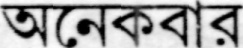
অনেকবার
